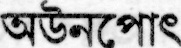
অউনপোৎ
